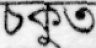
চকুত
